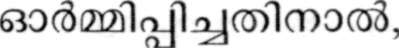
ഓര്‍മ്മിപ്പിച്ചതിനാല്‍,
